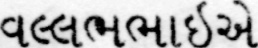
વલ્લભભાઈએ
